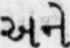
અને
